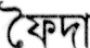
ফৈদা
